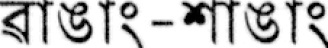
ৱাঙাং-শাঙাং
